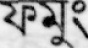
ফমুং
